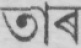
তাৰ
